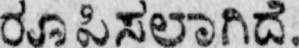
ರೂಪಿಸಲಾಗಿದೆ.
